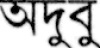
অদুবু
